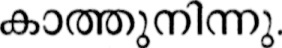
കാത്തുനിന്നു.
